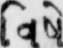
વિષે
